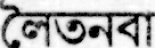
লৈতনবা
